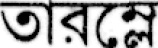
তারম্লে
